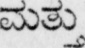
ಮತ್ತು
